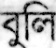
বুলি
